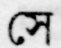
সে
